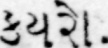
કયરો.
